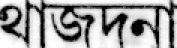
থাজদনা
